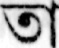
তা
